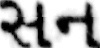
સન
